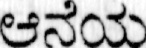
ಆನೆಯ
